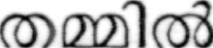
തമ്മില്‍
